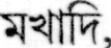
মখাদি,
